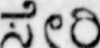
ಸೇರಿ
